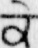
ਕੇ
